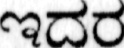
ಇದರ
